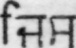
ਜਿਸ
